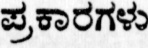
ಪ್ರಕಾರಗಳು
